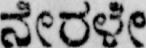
ನೇರಳೇ
